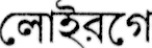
লোইরগে
